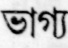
ভাগ্য
